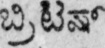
ಬ್ರಿಟಿಷ್
